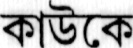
কাউকে
